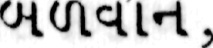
બળવાન,
